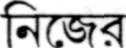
নিজের
